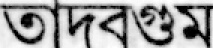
তাদবগুম
